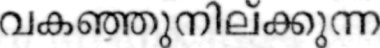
വകഞ്ഞുനില്ക്കുന്ന
